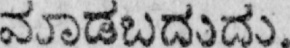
ಮಾಡಬದುದು.
